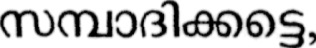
സമ്പാദിക്കട്ടെ,
